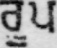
ਰੂਪ
